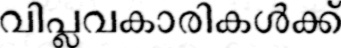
വിപ്ലവകാരികള്‍ക്ക്
